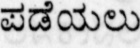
ಪಡೆಯಲು
